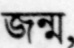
জন্ম,
